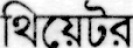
থিয়েটর
